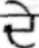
ਦੇ
